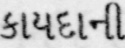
કાયદાની
